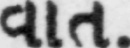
વાત.
